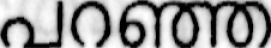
പറഞ്ഞ
